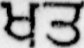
ਖਤ
